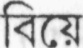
বিয়ে
